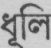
ধূলি
